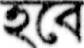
হবে
